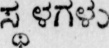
ಸ್ಥಳಗಳು
